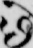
છે
